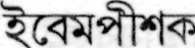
ইবেমপীশক
